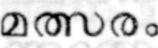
മത്സരം
